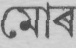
মোৰ
